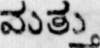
ಮತ್ತು
